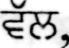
ਵੱਲ,
